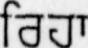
ਰਿਹਾ
